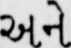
અને
